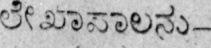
ಲೇಖಾಪಾಲನು-
